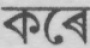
কৰে
